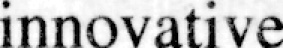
innovative
